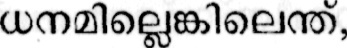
ധനമില്ലെങ്കിലെന്ത്,
